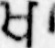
ਖਾ
